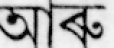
আৰু
